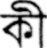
কী
